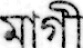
মাগী
